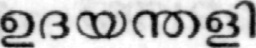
ഉദയന്തളി
